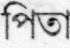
পিতা
